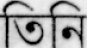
তিনি
